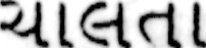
ચાલતા
